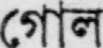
গোল
